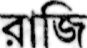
রাজি
